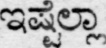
ಇಷ್ಟೆಲ್ಲಾ
